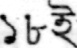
১৮ই
